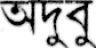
অদুবু
